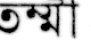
তম্মী
